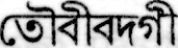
তৌবীবদগী
